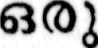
ഒരു
